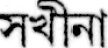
সখীনা
